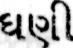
ઘણી
